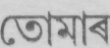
তোমাৰ
